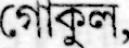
গোকুল
